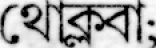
থোক্লবা;
